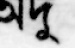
অদু
